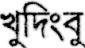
খুদিংবু
